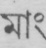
মাং
